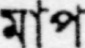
মাপ
